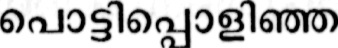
പൊട്ടിപ്പൊളിഞ്ഞ
